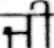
ਜੀ
